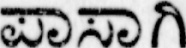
ಪಾಸಾಗಿ
